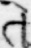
તે
